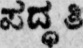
ಪದ್ಧತಿ
